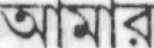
আমার
